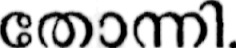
തോന്നി.
